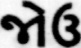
જોઉ
